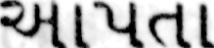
આપતા
